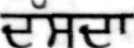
ਦੱਸਦਾ
